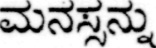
ಮನಸ್ಸನ್ನು
